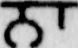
ਨਾ
